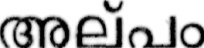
അല്പം
